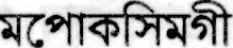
মপোকসিমগী
